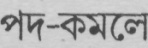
পদ-কমলে
